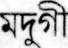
মদুগী
